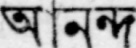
আনন্দ
